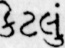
કેટલું
